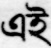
এই
